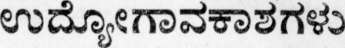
ಉದ್ಯೋಗಾವಕಾಶಗಳು
